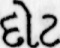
દોટ
